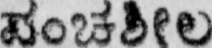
ಪಂಚಶೀಲ
